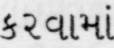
કરવામાં
